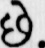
છે.
